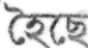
হৈছে
